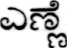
ಎಣ್ಣೆ
